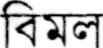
বিমল
